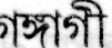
গঙ্গাগী
